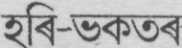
হৰি-ভকতৰ
